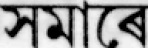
সমাৰে
